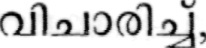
വിചാരിച്ച്,
